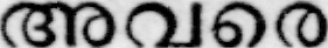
അവരെ
